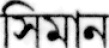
সিমান
